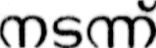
നടന്ന്
